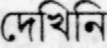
দেখিনি
